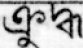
ক্রুদ্ধ
